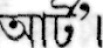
আর্ট’।
